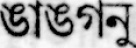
ঙাঙগনু
